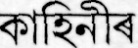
কাহিনীৰ
